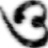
ও
